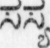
ಸಸ್ಯ
